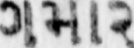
ગમાર
